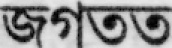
জগতত
